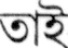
তাই
